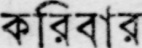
করিবার
